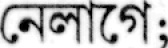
নেলাগে;
